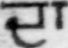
ਦਾ
